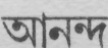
আনন্দ
